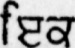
ਇਕ
